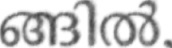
ങ്ങില്‍,
